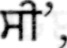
ਸੀ',
